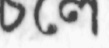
চলে
